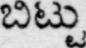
ಬಿಟ್ಟು
